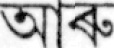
আৰু
